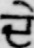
ਦੇ
